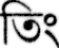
তিং
